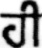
ਹੀ
